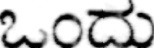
ಒಂದು
